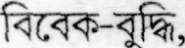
বিবেক-বুদ্ধি,
